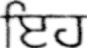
ਇਹ
